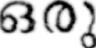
ഒരു
